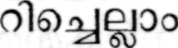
റിച്ചെല്ലാം
